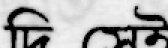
দি
